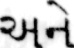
અને
